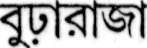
বুঢ়ারাজা
